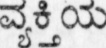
ವ್ಯಕ್ತಿಯ
